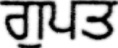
ਗੁਪਤ
